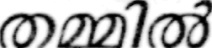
തമ്മില്‍
